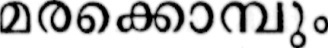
മരക്കൊമ്പും
